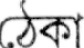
ঠেকা
